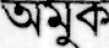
অমুক
